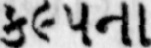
કલ્પના
